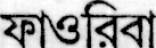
ফাওরিবা
